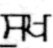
ਸੁਖ
